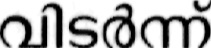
വിടര്‍ന്ന്
